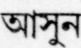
আসুন
